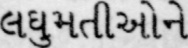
લઘુમતીઓને
